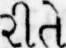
રીતે
